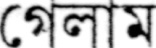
গেলাম
